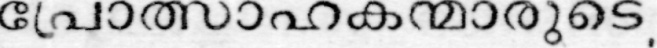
പ്രോത്സാഹകന്മാരുടെ
